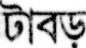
টাবড়
